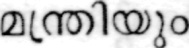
മന്ത്രിയും
